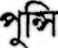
পুন্সি
